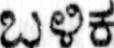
ಬಳಿಕ
